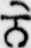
ਨੇ
